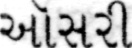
ઑસરી
